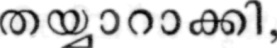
തയ്യാറാക്കി,
